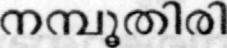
നമ്പൂതിരി
